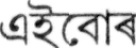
এইবোৰ
